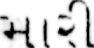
મારી
